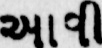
આવી
